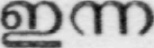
ഇന്ന
